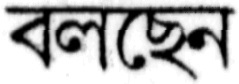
বলছেন
